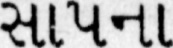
સાપના
